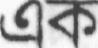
এক
